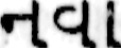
નવા
